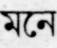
মনে
